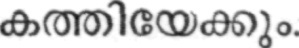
കത്തിയേക്കും.
